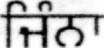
ਜਿੰਨਾ
